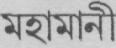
মহামানী
